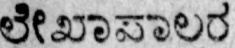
ಲೇಖಾಪಾಲರ
